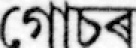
গোচৰ
